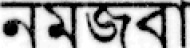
নমজবা
